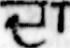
ਦਾ
